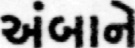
અંબાને
